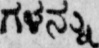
ಗಳನ್ನು
